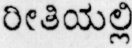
ರೀತಿಯಲ್ಲಿ
